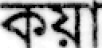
কয়া
